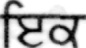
ਇਕ
